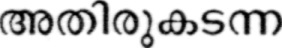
അതിരുകടന്ന
